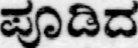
ಪೂಡಿದ
